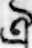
ঐ
